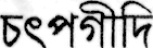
চৎপগীদি
